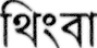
থিংবা
